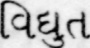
વિદ્યુત
